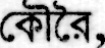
কৌরৈ,
